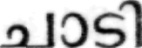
ചാടി
